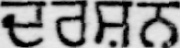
ਦਰਸ਼ਨ
